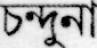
চন্দুনা
